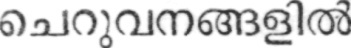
ചെറുവനങ്ങളില്‍
